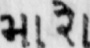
મારો
